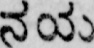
ನಯ
